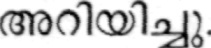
അറിയിച്ചു.
